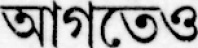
আগতেও
